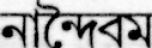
নান্দৈবম
